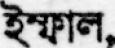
ইম্ফাল,
